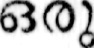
ഒരു
